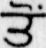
ਤੋਂ
